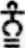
ਨੂੰ
